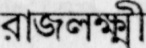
রাজলক্ষ্মী
